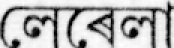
লেৰেলা
